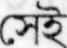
সেই
